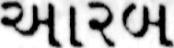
આરબ
